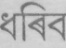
ধৰিব
